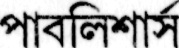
পাবলিশার্স
